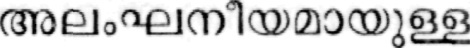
അലംഘനീയമായുള്ള
